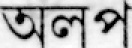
অলপ
